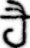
ਹੈ
